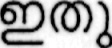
ഇതു
